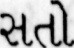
સતો
